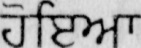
ਹੋਇਆ
